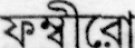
ফম্বীরো
